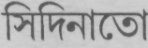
সিদিনাতো
